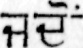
ਜਦੋਂ
